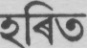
হৰিত
